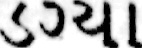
ડગ્યા
